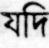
যদি
